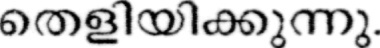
തെളിയിക്കുന്നു.
